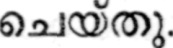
ചെയ്തു.
